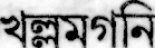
খল্লমগনি
